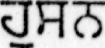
ਹੁਸਨ
